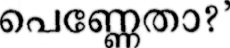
പെണ്ണേതാ?’
